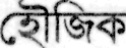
হৌজিক
